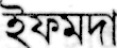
ইফমদা
